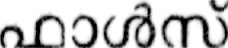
ഫാള്‍സ്
